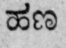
ಹಣ
